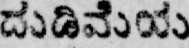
ದುಡಿಮೆಯ
